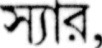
স্যার,
